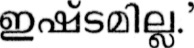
ഇഷ്ടമില്ല.’
